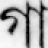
গা
